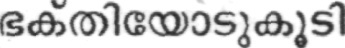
ഭക്തിയോടുകൂടി
